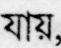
যায়,
